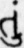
તું
